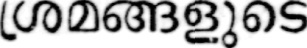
ശ്രമങ്ങളുടെ
